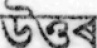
উত্তৰ
